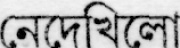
নেদেখিলো
